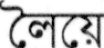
লৈয়ে
